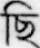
ছি
